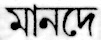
মানদে
